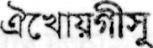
ঐখোয়গীসু
